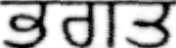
ਭਗਤ
